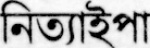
নিত্যাইপা
